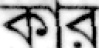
ওইরম্লে
